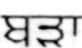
ਬੜਾ
